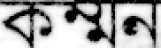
কম্মন
